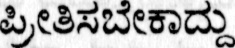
ಪ್ರೀತಿಸಬೇಕಾದ್ದು
